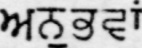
ਅਨੁਭਵਾਂ
